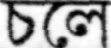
চলে
